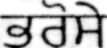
ਭਰੋਸੇ
